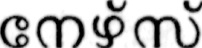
നേഴ്സ്
